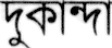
দুকান্দা
